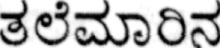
ತಲೆಮಾರಿನ
